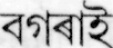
বগৰাই
